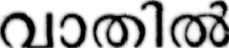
വാതില്‍
